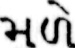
મળે
